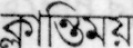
ক্লান্তিময়
